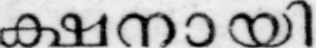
ക്ഷനായി
